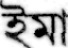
ইমা
